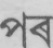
পৰ
